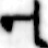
ન
